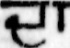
ਦਾ
